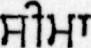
ਸੀਮਾ
